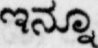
ಇನ್ನೂ
